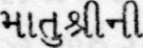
માતુશ્રીની
